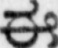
ಈ
